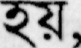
হয়,
